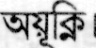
অয়ূক্নি।
